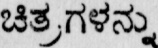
ಚಿತ್ರಗಳನ್ನು
